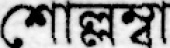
শোল্লম্বা
